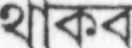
থাকব
